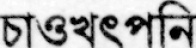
চাওখৎপনি
